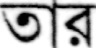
তার
